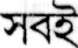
সবই
